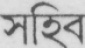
সহিব
